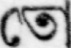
তো
